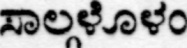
ಸಾಲ್ಗಳೊಳಂ
